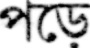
পড়ে
